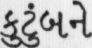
કુટુંબને
